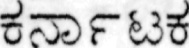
ಕರ್ನಾಟಕ
